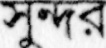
সুন্দর
